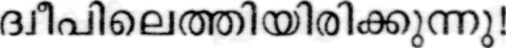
ദ്വീപിലെത്തിയിരിക്കുന്നു!
